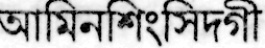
আমিনশিংসিদগী
